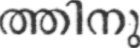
ത്തിനു
